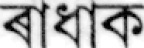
ৰাধাক
